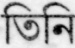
তিনি
